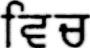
ਵਿਚ
